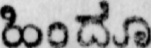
ಹಿಂದೂ
